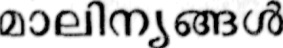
മാലിന്യങ്ങള്‍
